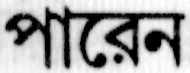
পারেন
